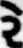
રે
